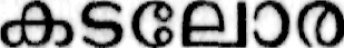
കടലോര
